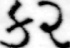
કર
